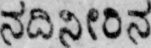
ನದಿನೀರಿನ
